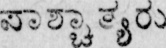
ಪಾಶ್ಚಾತ್ಯರು
